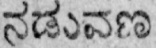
ನಡುವಣ
